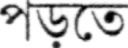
পড়তে
